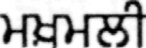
ਮਖ਼ਮਲੀ
